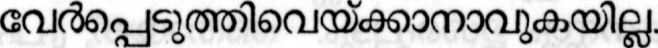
വേര്‍പ്പെടുത്തിവെയ്ക്കാനാവുകയില്ല.
